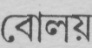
বোলয়
